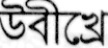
উবীখ্রে
